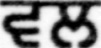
ਵਲ
